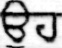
ਉਹ
